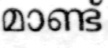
മാണ്ട്
